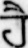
ਹੈ
